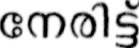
നേരിട്ട്
